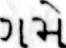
ગમે
